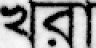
খরা
